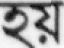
হয়
